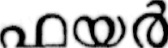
ഫയര്‍
